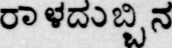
ರಾಳದುಬ್ಬಿನ
